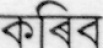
কৰিব
